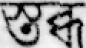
স্তব্ধ
